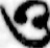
ও
